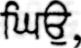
ਘਿਉ,
